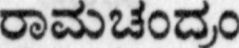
ರಾಮಚಂದ್ರಂ
